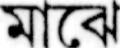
মাঝে
